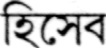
হিসেব
